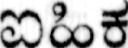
ಐಹಿಕ
